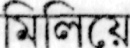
মিলিয়ে
